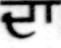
ਦਾ
